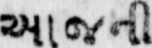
આજની
